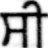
ਸੀ
